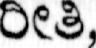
ರೀತಿ,
